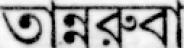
তান্নরুবা
